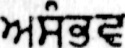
ਅਸੰਭਵ
